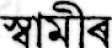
স্বামীৰ
